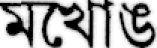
মখোঙ
